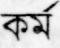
কর্ম
